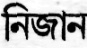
নিজান
